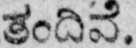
ತಂದಿವೆ.
